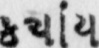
ક્યાંય
